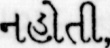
નહોતી,
